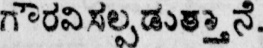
ಗೌರವಿಸಲ್ಪಡುತ್ತಾನೆ.
